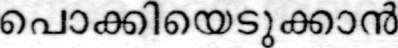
പൊക്കിയെടുക്കാന്‍
